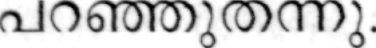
പറഞ്ഞുതന്നു.
